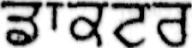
ਡਾਕਟਰ
